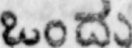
ಒಂದು
